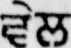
ਵੇਲ
